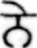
ਨੇ
